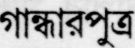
গান্ধারপুত্র
